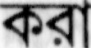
করা
